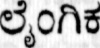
ಲೈಂಗಿಕ
